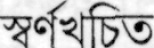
স্বর্ণখচিত
